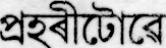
প্রহৰীটোৱে
